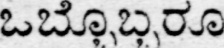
ಒಬ್ಬೊಬ್ಬರೂ
